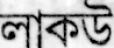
লাকউ
